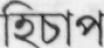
হিচাপ
